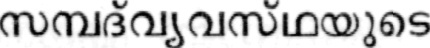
സമ്പദ്വ്യവസ്ഥയുടെ
